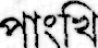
পাংখি
